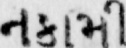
નકામી
